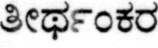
ತೀರ್ಥಂಕರ
